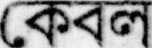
কেবল
